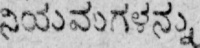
ನಿಯಮಗಳನ್ನು
